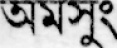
অমসুং
